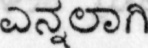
ಎನ್ನಲಾಗಿ
